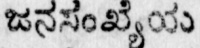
ಜನಸಂಖ್ಯೆಯ
